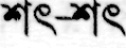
শৎ-শৎ
